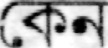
কেন
